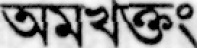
অমখক্তং
